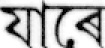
যাৰে
